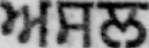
ਅਸਲ
